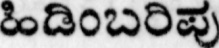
ಹಿಡಿಂಬರಿಪು
